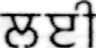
ਲਈ
